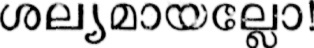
ശല്യമായല്ലോ!
